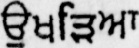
ਉਖੜਿਆ
